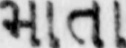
માતા
